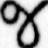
જ
